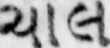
ચાલ
